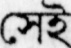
সেই
